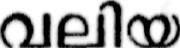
വലിയ
